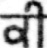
ਕੀ
